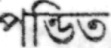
পন্ডিত
